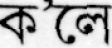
ক'লে
